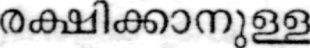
രക്ഷിക്കാനുള്ള
